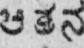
ಆತನ
